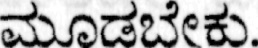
ಮೂಡಬೇಕು.
